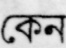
কেন
